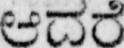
ಆದರೆ
